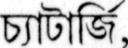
চ্যাটার্জি,
